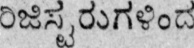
ರಿಜಿಸ್ಟರುಗಳಿಂದ
